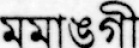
মমাঙগী
